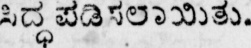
ಸಿದ್ಧಪಡಿಸಲಾಯಿತು.
